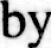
by
